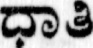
ಧಾತಿ
